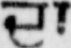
ਦਾ
